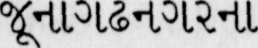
જૂનાગઢનગરના
